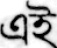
এই
